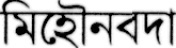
মিহৌনবদা
